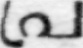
പ്ര
